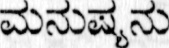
ಮನುಷ್ಯನು
